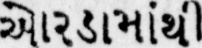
ઓરડામાંથી
